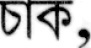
চাক,
